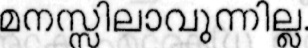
മനസ്സിലാവുന്നില്ല.
